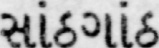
સાંઠગાંઠ
